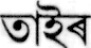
তাইৰ
